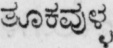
ತೂಕವುಳ್ಳ
